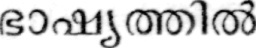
ഭാഷ്യത്തില്‍
